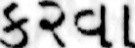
કરવા
